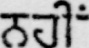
ਨਹੀਂ
